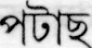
পটাছ
